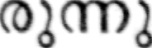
രുന്നു
